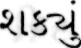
શક્યું
